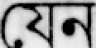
যেন
